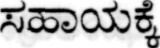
ಸಹಾಯಕ್ಕೆ
